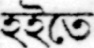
হইতে
